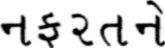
નફરતને
